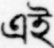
এই
